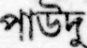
পাউদু
